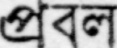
প্রবল
